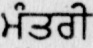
ਮੰਤਰੀ
